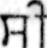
ਸੀ
